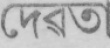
দেৱতা
